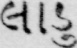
લાડુ
